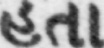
હતા
